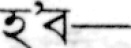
হ'ব-
